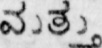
ಮತ್ತು
